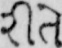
રીતે
